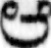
ಆ
